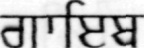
ਗਾਇਬ
